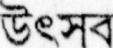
উত্সব
